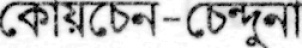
কোয়চেন-চেন্দুনা
